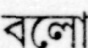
বলো
